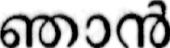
ഞാന്‍
